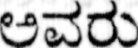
ಅವರು
